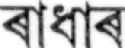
ৰাধাৰ
